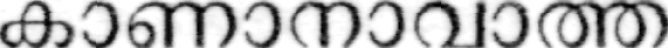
കാണാനാവാത്ത
